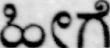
ಹೀಗೆ
